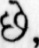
છે,
